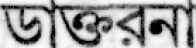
ডাক্তরনা
